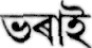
ভৰাই
